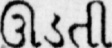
ઊડતી
